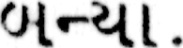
બન્યા.
